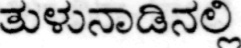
ತುಳುನಾಡಿನಲ್ಲಿ
